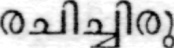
രചിച്ചിരു
